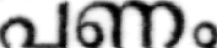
പണം
